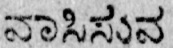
ವಾಸಿಸುವ
